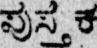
ಪುಸ್ತಕ
